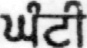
ਘੰਟੀ
